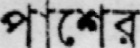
পাশের
